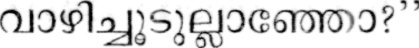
വാഴിച്ചൂടുല്ലാഞ്ഞോ?"
